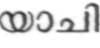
യാചി
